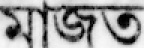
মাজত
